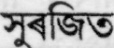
সুৰজিত
